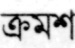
ক্রমশ
